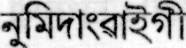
নুমিদাংৱাইগী
